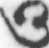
ও
